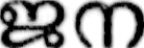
ജന
